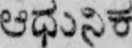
ಆಧುನಿಕ
